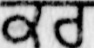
ਕਰ
